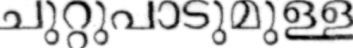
ചുറ്റുപാടുമുള്ള
